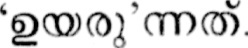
‘ഉയരു’ന്നത്.
